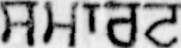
ਸਮਾਰਟ
